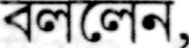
বললেন,
